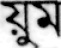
য়ুম
